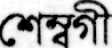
শেম্বগী
